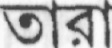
তারা
